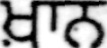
ਖ਼ਾਨ
